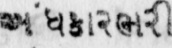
અંધકારભરી
